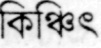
কিঞ্চিত্
